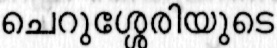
ചെറുശ്ശേരിയുടെ
